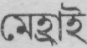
মেহ্রাই
